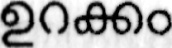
ഉറക്കം
